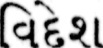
વિદેશ
